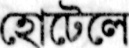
হোটেলে
